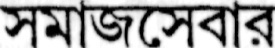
সমাজসেবার
